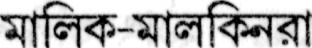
মালিক-মালকিনরা
